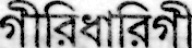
গীরিধারিগী
